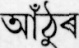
আঁঠুৰ
